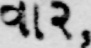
વાર,
